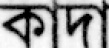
কাদা
